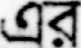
এর
